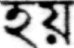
হয়
